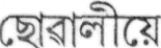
ছোৱালীয়ে
